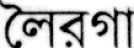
লৈরগা
